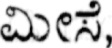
ಮೀಸೆ,
